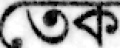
তেক
